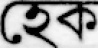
হেক
